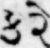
કરે
